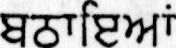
ਬਠਾਇਆਂ
